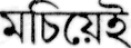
মচিয়েই
